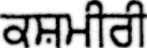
ਕਸ਼ਮੀਰੀ
